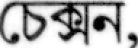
চেক্সন,
